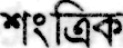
শংত্রিক
